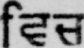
ਵਿਚ
